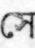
সে
